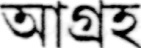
আগ্রহ
